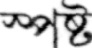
স্পষ্ট
